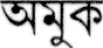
অমুক
